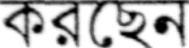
করছেন
